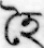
হৈ
